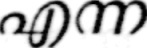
എന്ന
